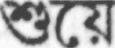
শুয়ে
